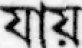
যায়
